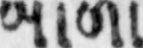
બાળા
